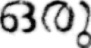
ഒരു
